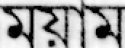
ময়াম
